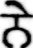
ਨੇ
